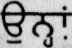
ਉਨ੍ਹਾਂ
